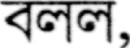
বলল,
